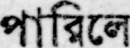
পারিলে
